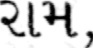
રામ,
